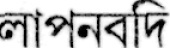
লাপনবদি
